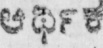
ಆರ್ಥಿಕ
